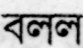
বলল
